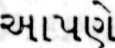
આપણે
